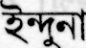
ইন্দুনা
